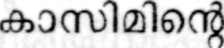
കാസിമിന്റെ
